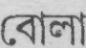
বোলা
